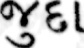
જુદા
